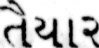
તૈયાર
